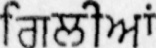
ਗਿਲੀਆਂ
